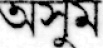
অসুম
